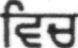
ਵਿਚ
